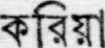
করিয়া
